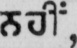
ਨਹੀਂ,
